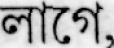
লাগে,
